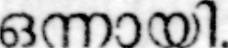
ഒന്നായി.
